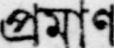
প্রমাণ
